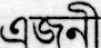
এজনী
